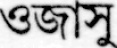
ওজাসু
